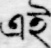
এই
